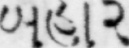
બહાર
